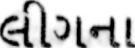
લીગના
